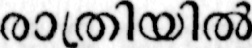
രാത്രിയില്‍
